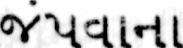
જંપવાના
